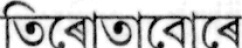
তিৰোতাবোৰে
